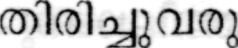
തിരിച്ചുവരു
